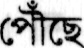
পৌঁছে
